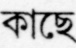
কাছে
